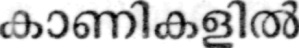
കാണികളില്‍
